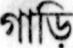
গাড়ি
